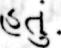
હતું.
